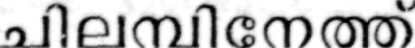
ചിലമ്പിനേത്ത്
